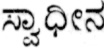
ಸ್ವಾಧೀನ
